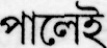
পালেই
